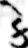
કે
